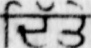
ਦਿੱਤੇ
